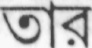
তার
